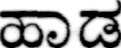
ಹಾಡ
